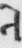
ને
